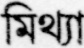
মিথ্যা
